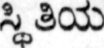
ಸ್ಥಿತಿಯ
